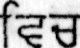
ਵਿਚ
